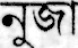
নুজা
